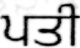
ਪਤੀ
